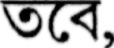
তবে,
